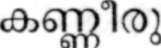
കണ്ണീരു
